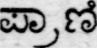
ಪ್ರಾಣಿ
